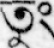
তুং
